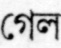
গেল
